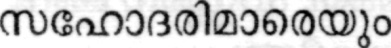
സഹോദരിമാരെയും
